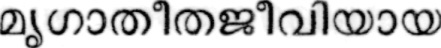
മൃഗാതീതജീവിയായ
